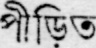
পীড়িত
